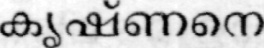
കൃഷ്ണനെ
